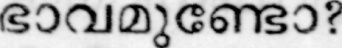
ഭാവമുണ്ടോ?
